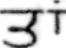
ਤਾਂ
